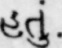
હતું.
